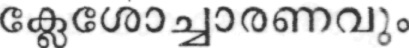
ക്ലേശോച്ചാരണവും
